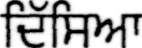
ਦਿੱਸਿਆ
